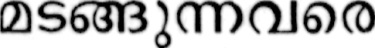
മടങ്ങുന്നവരെ
